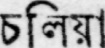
চলিয়া
